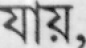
যায়,
